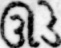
ઊડે
